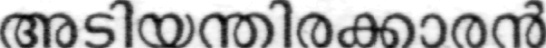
അടിയന്തിരക്കാരന്‍
